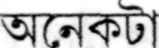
অনেকটা
